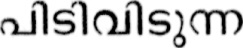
പിടിവിടുന്ന
